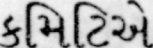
કમિટિએ
